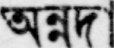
অন্নদা
